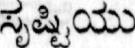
ಸೃಷ್ಟಿಯು
